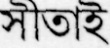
সীতাই
